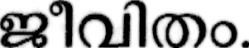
ജീവിതം.
